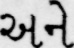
અને
